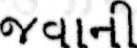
જવાની
